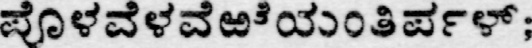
ಪೊಳವೆಳವೆಱೆಯಂತಿರ್ಪಳ್
